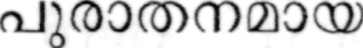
പുരാതനമായ
